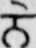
ਨੇ
